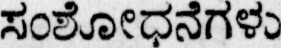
ಸಂಶೋಧನೆಗಳು
